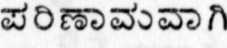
ಪರಿಣಾಮವಾಗಿ
